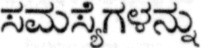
ಸಮಸ್ಯೆಗಳನ್ನು
